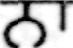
ਨਾ
